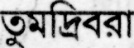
তুমদ্রিবরা
